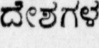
ದೇಶಗಳ
